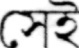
সেই
